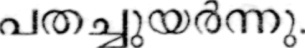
പതച്ചുയര്‍ന്നു.
